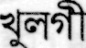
খুলগী
